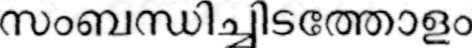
സംബന്ധിച്ചിടത്തോളം
